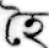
হৈ
